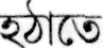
হঠাতে
